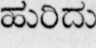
ಹುರಿದು
